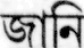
জানি
